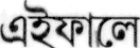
এইফালে
